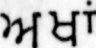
ਅਖਾਂ
